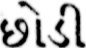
છોડી
